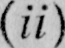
(ii)
